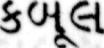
કબૂલ
